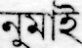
নুমাই
